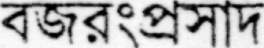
বজরংপ্রসাদ
